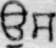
ਉਸ
